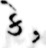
કે,
